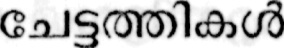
ചേട്ടത്തികള്‍
